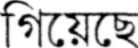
গিয়েছে
